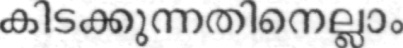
കിടക്കുന്നതിനെല്ലാം
